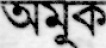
অমুক
